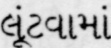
લૂંટવામાં
